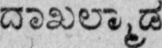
ದಾಖಲ್ಮಾಡ
